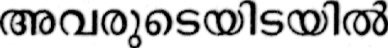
അവരുടെയിടയില്‍
